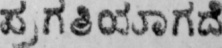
ಪ್ರಗತಿಯಾಗದೆ
